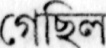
গেছিল
